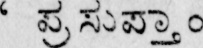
‘ಪ್ರಸುಪ್ತಾಂ
